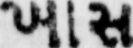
ખાસ
